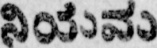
ನಿಯಮ
